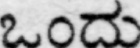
ಒ೦ದು
